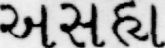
અસહ્ય
